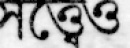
সত্ত্বেও
